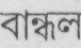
বান্ধল
